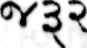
જરૂર
